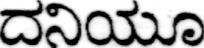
ದನಿಯೂ
